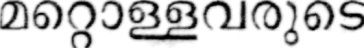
മറ്റൊള്ളവരുടെ
